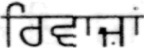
ਰਿਵਾਜ਼ਾਂ
